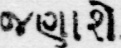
જણાશે
